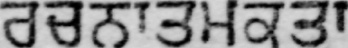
ਰਚਨਾਤਮਕਤਾ
